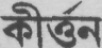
কীৰ্ত্তন
